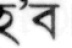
হ'ব
